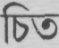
চিত
